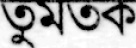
তুমতক
